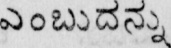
ಎಂಬುದನ್ನು
